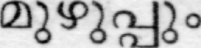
മുഴുപ്പും
